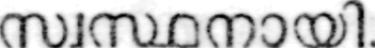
സ്വസ്ഥനായി.
